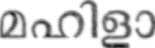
മഹിളാ
